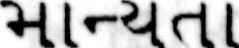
માન્યતા
